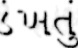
ડંખતું
